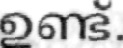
ഉണ്ട്.
